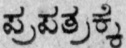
ಪ್ರಪತ್ರಕ್ಕೆ
